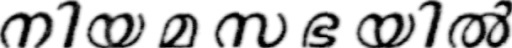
നിയമസഭയില്‍
